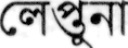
লেপ্তুনা
